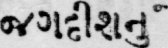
જગદીશનું
